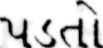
પડતો
